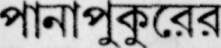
পানাপুকুরের
